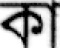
কা
